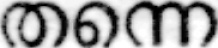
തന്നെ
